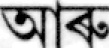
আৰু
